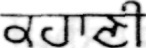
ਕਹਾਣੀ
